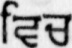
ਵਿਚ
